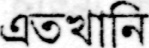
এতখানি
